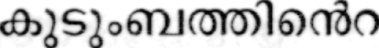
കുടുംബത്തിന്റെ
